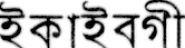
ইকাইবগী
